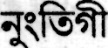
নুংতিগী
